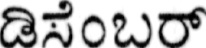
ಡಿಸೆಂಬರ್
